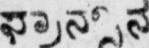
ಫ್ರಾನ್ಸ್‌ನ
